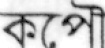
কপৌ
